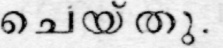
ചെയ്തു.
